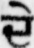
ਦੇ
